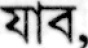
যাব,
